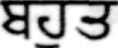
ਬਹੁਤ
